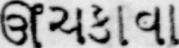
ઊંચકાવા
